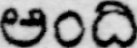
ಅ೦ದಿ
